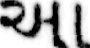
આ
